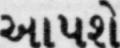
આપશે
